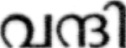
വന്ദി
